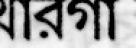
থারগা
